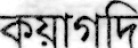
কয়াগদি
